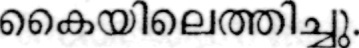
കൈയിലെത്തിച്ചു.
